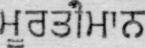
ਮੂਰਤੀਮਾਨ
